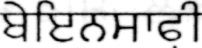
ਬੇਇਨਸਾਫ਼ੀ
